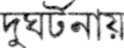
দুঘর্টনায়
